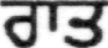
ਰਾਤ
